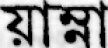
য়াম্না
